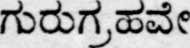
ಗುರುಗ್ರಹವೇ
